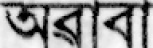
অৱাবা
